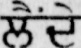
ਲੈਂਦੇ
